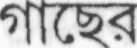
গাছের
